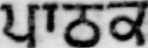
ਪਾਠਕ
